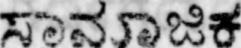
ಸಾಮಾಜಿಕ
